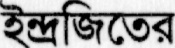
ইন্দ্রজিতের
